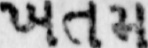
ખતમ
